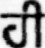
ਹੀ
